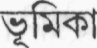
ভূমিকা
